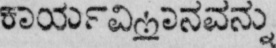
ಕಾರ್ಯವಿಧಾನವನ್ನು
